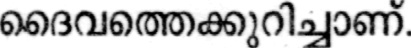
ദൈവത്തെക്കുറിച്ചാണ്.
